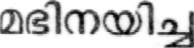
മഭിനയിച്ച
